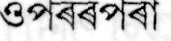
ওপৰৰপৰা
